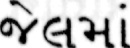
જેલમાં
